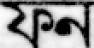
ফন
